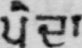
ਪੈਦਾ
